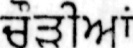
ਚੌੜੀਆਂ
